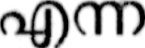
എന്ന
